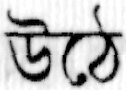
উঠে
